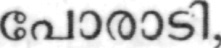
പോരാടി,
